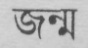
জন্ম
